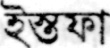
ইস্তফা
